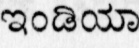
ಇಂಡಿಯಾ
